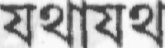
যথাযথ
